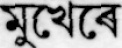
মুখেৰে
